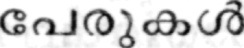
പേരുകള്‍
